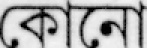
কোনো
